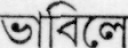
ভাবিলে
